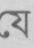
যে
